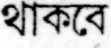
থাকবে
